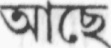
আছে
